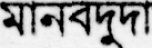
মানবদুদা
